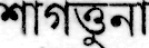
শাগত্তুনা
